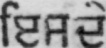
ਇਸਦੇ
